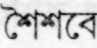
শৈশবে
